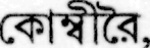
কোম্বীরৈ,
